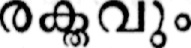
രക്തവും
